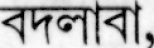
বদলাবা,
